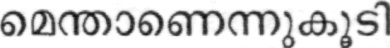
മെന്താണെന്നുകൂടി
